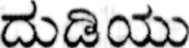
ದುಡಿಯು
